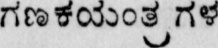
ಗಣಕಯಂತ್ರ
